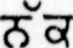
ਨੱਕ
